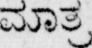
ಮಾತ್ರ
